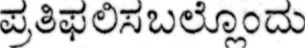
ಪ್ರತಿಫಲಿಸಬಲ್ಲೊಂದು
